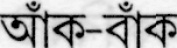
আঁক-বাঁক
